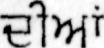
ਦੀਆਂ
